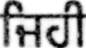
ਜਿਹੀ
